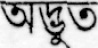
অদ্ভুত
